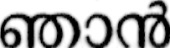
ഞാന്‍
